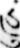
હું
